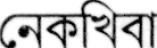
নেকখিবা
